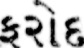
ફરોદ
